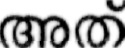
അത്
